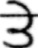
ਤੇ
